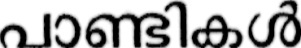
പാണ്ടികള്‍
